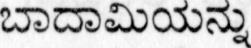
ಬಾದಾಮಿಯನ್ನು
